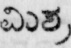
ಮಿಶ್ರ
